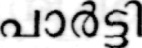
പാര്‍ട്ടി
